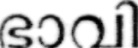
ഭാവി
